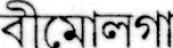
বীমোলগা
